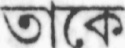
তাকে
